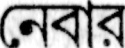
নেবার
